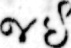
જઈ
